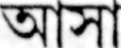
আসা
